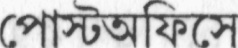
পোস্টঅফিসে
